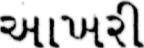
આખરી
